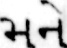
મને
